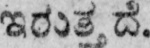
ಇರುತ್ತದೆ.
